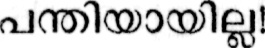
പന്തിയായില്ല!
